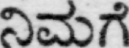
ನಿಮಗೆ
